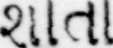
શાતા
